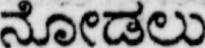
ನೋಡಲು
